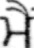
ਮੈਂ
